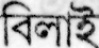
বিলাই
